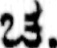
ಚ.
